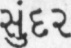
સુંદર
